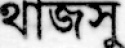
থাজসু
